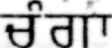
ਚੰਗਾ
